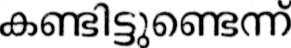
കണ്ടിട്ടുണ്ടെന്ന്
